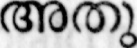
അതു
